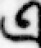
এ
